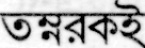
তম্নরকই
